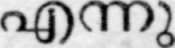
എന്നു
